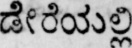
ಡೇರೆಯಲ್ಲಿ
